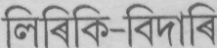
লিৰিকি-বিদাৰি
